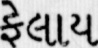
ફેલાય
